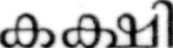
കക്ഷി
